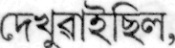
দেখুৱাইছিল,
